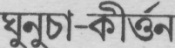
ঘুনুচা-কীৰ্ত্তন
